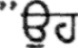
''ਉਹ
